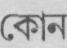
কোন
